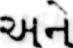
અને
